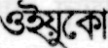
ওইয়ুকো
